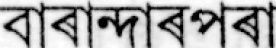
বাৰান্দাৰপৰা
